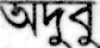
অদুবু
